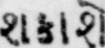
શકાશે
